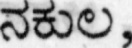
ನಕುಲ,
